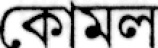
কোমল
